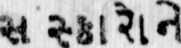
સંસ્કારોને
